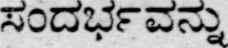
ಸಂದರ್ಭವನ್ನು
